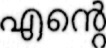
എന്റെ
